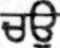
ਚਉ
